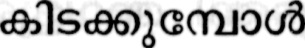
കിടക്കുമ്പോള്‍
